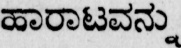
ಹಾರಾಟವನ್ನು
